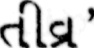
તીવ્ર'
